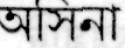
অসিনা
